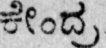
ಕೇಂದ್ರ.
